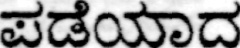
ಪಡೆಯಾದ
